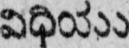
ವಿಧಿಯು
